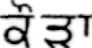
ਕੌੜਾ
